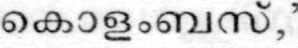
കൊളംബസ്’,
